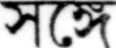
সঙ্গে
